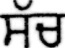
ਸੱਚ
